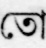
তো
